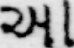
આ
